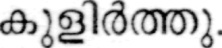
കുളിര്‍ത്തു.
